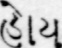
હોય
